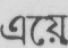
এয়ে
